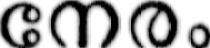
നേരം
